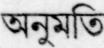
অনুমতি
